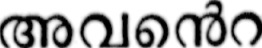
അവന്റെ
